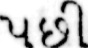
પછી
